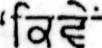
'ਕਿਵੇਂ
